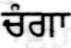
ਚੰਗਾ
